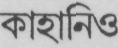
কাহানিও
